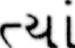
ત્યાં
